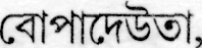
বোপাদেউতা,
